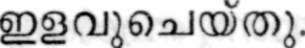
ഇളവുചെയ്തു.
